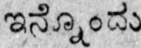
ಇನ್ನೊಂದು
